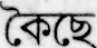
কৈছে
